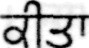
ਕੀਤਾ
